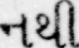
નથી
